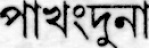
পাখংদুনা
